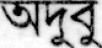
অদুবু
